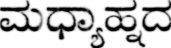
ಮಧ್ಯಾಹ್ನದ
